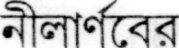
নীলার্ণবের
